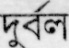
দুর্বল
